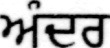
ਅੰਦਰ
